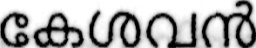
കേശവന്‍
